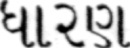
ધારણ
